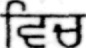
ਵਿਚ
